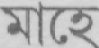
মাহে
